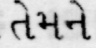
તેમને
